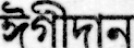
ঈগীদান
